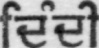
ਦਿੰਦੀ
